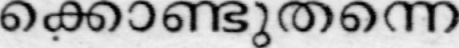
ക്കൊണ്ടുതന്നെ
